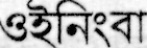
ওইনিংবা
